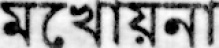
মখোয়না
